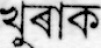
খুৰাক
